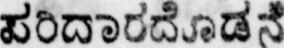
ಪರಿದಾರದೊಡನೆ
